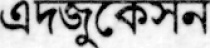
এদজুকেসন
